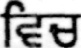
ਵਿਚ
